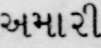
અમારી
